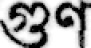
গুণ
